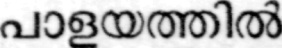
പാളയത്തില്‍
